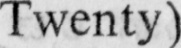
Twenty)
